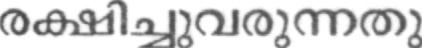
രക്ഷിച്ചുവരുന്നതു
